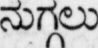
ನುಗ್ಗಲು
